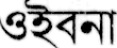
ওইবনা
